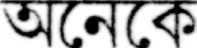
অনেকে
